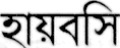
হায়বসি
